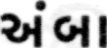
અંબા
